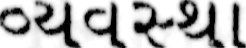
વ્યવસ્થા
